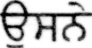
ਉਸਨੇ
